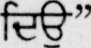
ਦਿਉ''
